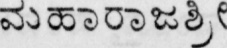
ಮಹಾರಾಜಶ್ರೀ
